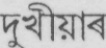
দুখীয়াৰ
